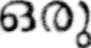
ഒരു
